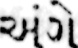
અંગે
